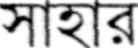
সাহার
